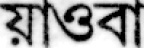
য়াওবা
